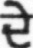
ਦੇ
